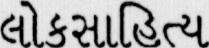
લોકસાહિત્ય
